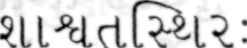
શાશ્વતસ્થિરઃ
